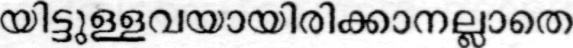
യിട്ടുള്ളവയായിരിക്കാനല്ലാതെ
